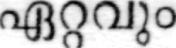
ഏറ്റവും
